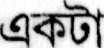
একটা
